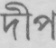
দীপ
